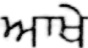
ਆਖੇ
